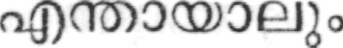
എന്തായാലും
